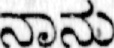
ನಾನು
